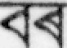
বৰ
